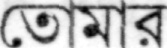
তোমার
